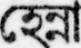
হেন্না
